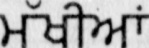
ਮੱਖੀਆਂ
